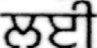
ਲਈ
